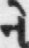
ને
